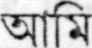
আমি
